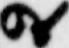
જ
